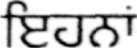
ਇਹਨਾਂ
